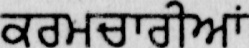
ਕਰਮਚਾਰੀਆਂ
